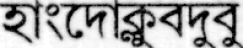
হাংদোক্লুবদুবু
